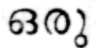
ഒരു
